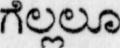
ಗೆಲ್ಲಲೂ
